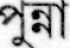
পুন্না
